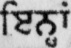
ਇਨ੍ਹਾਂ
